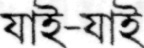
যাই-যাই
